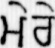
ਮੇਰੇ
